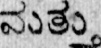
ಮತ್ತು
